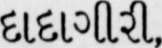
દાદાગીરી,
